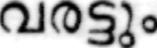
വരട്ടും
